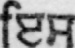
ਇਸ
